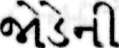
જોડેની
